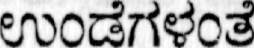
ಉಂಡೆಗಳಂತೆ
